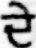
ਦੇ
